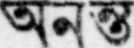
অনন্ত
